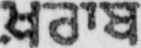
ਖ਼ਰਾਬ
